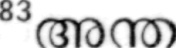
83അന്ത
